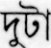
দুটা
